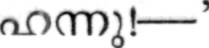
ഹന്നു!-'
